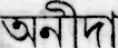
অনীদা
